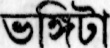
ভঙ্গিটা
